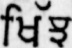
ਖਿੱਝ
